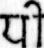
ਧੀ
